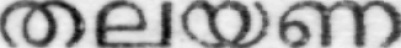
തലയണ
